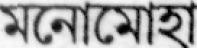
মনোমোহা
